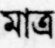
মাত্র
